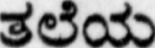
ತಲೆಯ
